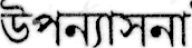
উপন্যাসনা
